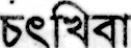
চৎখিবা
